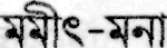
মমীৎ-মনা
